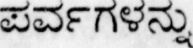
ಪರ್ವಗಳನ್ನು
